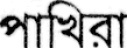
পাখিরা
